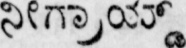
ನೀಗ್ರಾಯ್ಡ್
